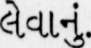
લેવાનું.
